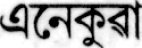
এনেকুৱা
